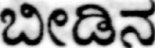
ಬೀಡಿನ
